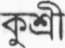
কুশ্রী
